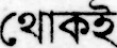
থোকই
